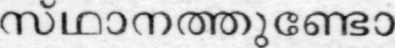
സ്ഥാനത്തുണ്ടോ
